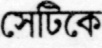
সেটিকে
